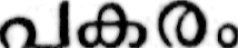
പകരം
